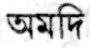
অমদি
